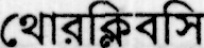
থোরক্লিবসি
